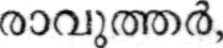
രാവുത്തര്‍,
